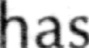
has
